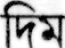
দিম
